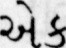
એક
